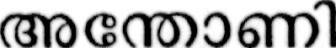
അന്തോണി
